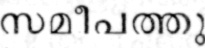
സമീപത്തു
